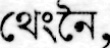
থেংনৈ,
